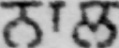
ਨਾਲ
